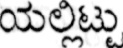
ಯಲ್ಲಿಟ್ಟು
